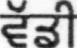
ਵੱਡੀ
